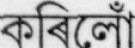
কৰিলোঁ
